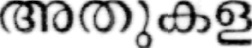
അതുകള
